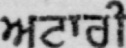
ਅਟਾਰੀ
